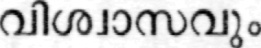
വിശ്വാസവും
